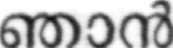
ഞാന്‍
